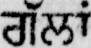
ਗੱਲਾਂ
